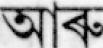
আৰু
